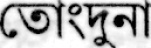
তোংদুনা
